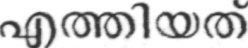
എത്തിയത്
